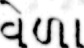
વેળા
